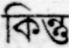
কিন্তু
